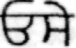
ਓਸੇ
